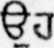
ਉਹ
